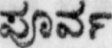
ಪೂರ್ವ
